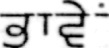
ਭਾਵੇਂ
